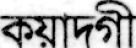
কয়াদগী
